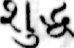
શુદ્ધ
